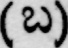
(ಬ)
